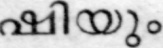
ഷിയും
